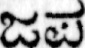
ಜಪ
